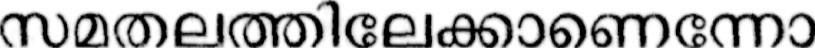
സമതലത്തിലേക്കാണെന്നോ
